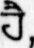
ਹੈ,
